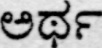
ಅರ್ಥ
